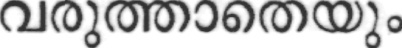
വരുത്താതെയും
